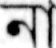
না
